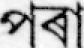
পৰা
